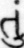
તું
